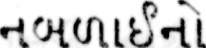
નબળાઈનો
